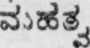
ಮಹತ್ವ
